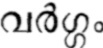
വര്‍ഗ്ഗം
